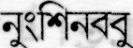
নুংশিনববু
